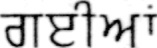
ਗਈਆਂ
